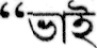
“ভাই
